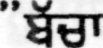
''ਬੱਚਾ
